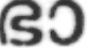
ഭാ
